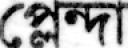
প্লেন্দা
